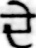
ਦੇ
